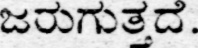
ಜರುಗುತ್ತದೆ.
